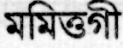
মমিত্তগী
